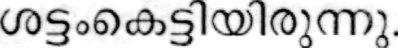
ശട്ടംകെട്ടിയിരുന്നു.
